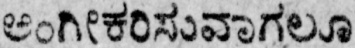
ಅಂಗೀಕರಿಸುವಾಗಲೂ
